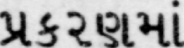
પ્રકરણમાં
